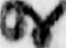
જ
